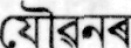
যৌৱনৰ
